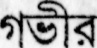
গভীর
